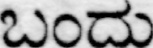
ಬಂದು
